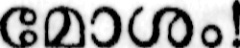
മോശം!
